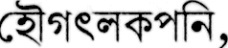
হৌগৎলকপনি,
